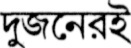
দুজনেরই
